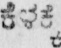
ಕೆಳಕ್ಕೆ
